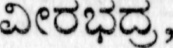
ವೀರಭದ್ರ,
